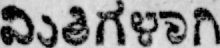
ಮಿತಿಗಳಾಗಿ
